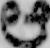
ಆ
